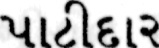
પાટીદાર
